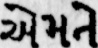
એમને
